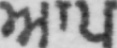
ਆਪ
